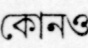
কোনও
